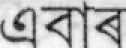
এবাৰ
